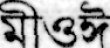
মীওঈ
